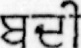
ਬਦੀ
